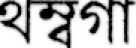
থম্বগা
